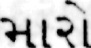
મારો
